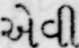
એવી
